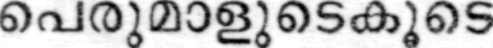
പെരുമാളുടെകൂടെ
